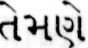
તેમણે
